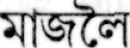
মাজলৈ
